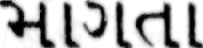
માગતા
